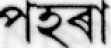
পহৰা
